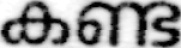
കണ്ട
